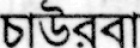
চাউরবা
